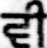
ਵੀ
